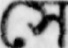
সে
